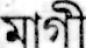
মাগী
